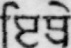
ਇਥੇ
